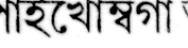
পাইখোম্বগা
